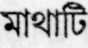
মাথাটি
